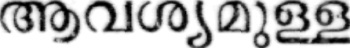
ആവശ്യമുള്ള
